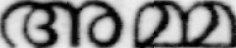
അമ്മ
